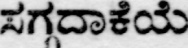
ಸಗ್ಗದಾಕೆಯ
